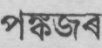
পঙ্কজৰ
